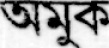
অমুক
